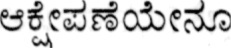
ಆಕ್ಷೇಪಣೆಯೇನೂ
